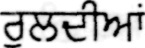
ਰੁਲਦੀਆਂ
